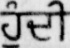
ਹੁੰਦੀ
